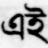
এই
